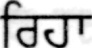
ਰਿਹਾ
